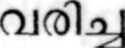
വരിച്ച
